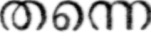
തന്നെ
